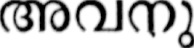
അവനു
